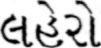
લહેરો
